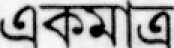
একমাত্ৰ
